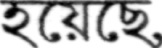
হয়েছে,
